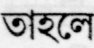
তাহলে
